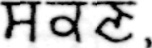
ਸਕਣ,
